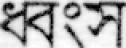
ধ্বংস
